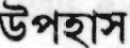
উপহাস
